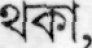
থকা,
